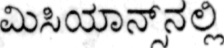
ಮಿಸಿಯಾನ್ಸ್ನಲ್ಲಿ
